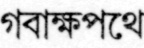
গবাক্ষপথে
